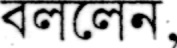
বললেন,
